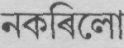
নকৰিলো
